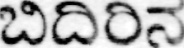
ಬಿದಿರಿನ
